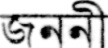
জননী
